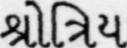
શ્રોત્રિય
